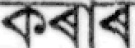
কৰাৰ
